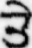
ਤੇ
